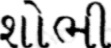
શોભી
